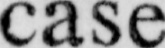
case
